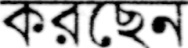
করছেন
